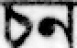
চন
